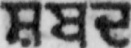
ਸ਼ਬਦ
